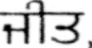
ਜੀਤ,
